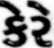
કેરે
